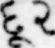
દૂર
